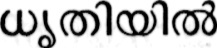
ധൃതിയില്‍
